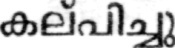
കല്പിച്ചു
